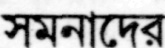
সমনাদের
